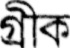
গ্রীক
